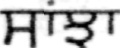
ਸਾਂਝਾ
